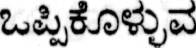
ಒಪ್ಪಿಕೊಳ್ಳುವ
